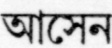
আসেন
